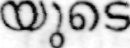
യുടെ
